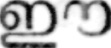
ഈ
